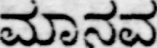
ಮಾನವ
